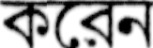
করেন
